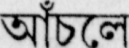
আঁচলে
